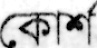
কোর্শ
